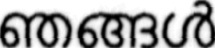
ഞങ്ങള്‍
